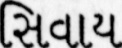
સિવાય
